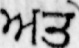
ਅਤੇ
